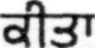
ਕੀਤਾ
